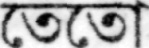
তেতো
